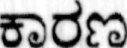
ಕಾರಣ
